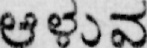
ಆಳುವ
